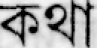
কথা
